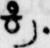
ಕ್ರಿ.
